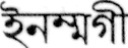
ইনম্মগী
